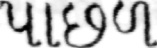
પાછળ
